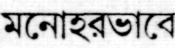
মনোহরভাবে
